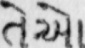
તેઓ
